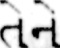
તેને
